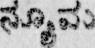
ನ್ಯೂಮ
